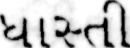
ધાસ્તી
